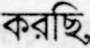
করছি,
